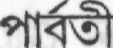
পার্বতী
